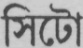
সিটো
